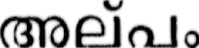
അല്പം
